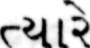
ત્યારે
